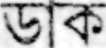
ডাক
